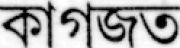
কাগজত
